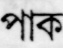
পাক
